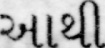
આથી
